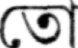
তো
